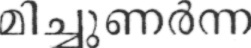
മിച്ചുണര്‍ന്ന
